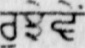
ਰੁਝੇਵੇਂ
